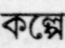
কল্পে
